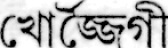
খোর্জ্জৈগী
